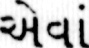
એવાં
